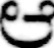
ಆ
